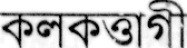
কলকত্তাগী
